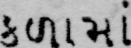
કળામાં
